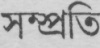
সম্প্ৰতি
